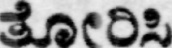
ತೋರಿಸಿ
